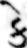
કે
